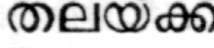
തലയക്ക
